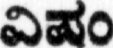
ವಿಷಂ
